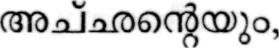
അച്ഛന്റെയും,
